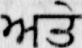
ਅਤੇ
